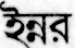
ইন্নর
